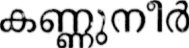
കണ്ണുനീര്‍
